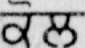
ਕੋਲ
